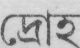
দ্ৰোহ
